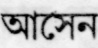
আসেন
